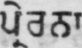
ਪ੍ਰੇਰਨਾ
